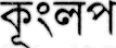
কূংলপ
